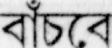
বাঁচবে
